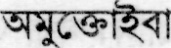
অমু্ক্তোইবা
